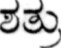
ಶತ್ರು
